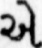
એ
